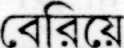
বেরিয়ে
